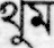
থুম
